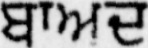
ਬਾਅਦ
